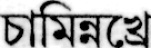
চামিন্নখ্রে
